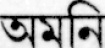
অমনি
